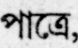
পাত্রে,
